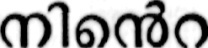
നിന്റെ
